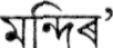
মন্দিৰ'
